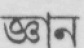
জ্ঞান
